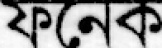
ফনেক
